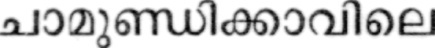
ചാമുണ്ഡിക്കാവിലെ
